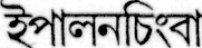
ইপালনচিংবা
